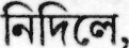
নিদিলে,
